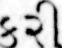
કરી
